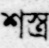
শস্ত্র
